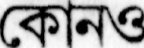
কোনও
